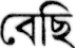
বেছি
